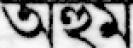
অহুম
